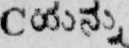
Cಯನ್ನು
